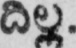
ದಿಲ್ಲ.
